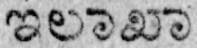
ಇಲಾಖಾ
